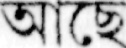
আছে
